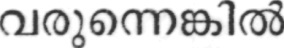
വരുന്നെങ്കില്‍
